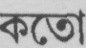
কতো
